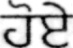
ਹੋਏ
